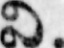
ವಿ.
